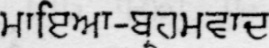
ਮਾਇਆ-ਬ੍ਰਹਮਵਾਦ
